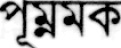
পূম্নমক
